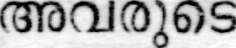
അവരുടെ
